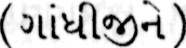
(ગાંધીજીને)
